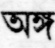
অঙ্গ
